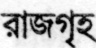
রাজগৃহ
